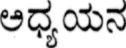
ಅಧ್ಯಯನ
